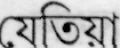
যেতিয়া
